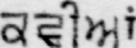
ਕਵੀਆਂ
